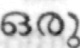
ഒരു
